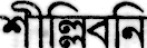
শীল্লিবনি
